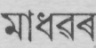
মাধৱৰ
